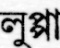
লুপ্পা
